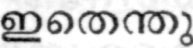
ഇതെന്തു
